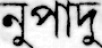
নুপাদু
